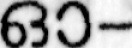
ഓ-
